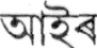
আইৰ
